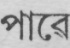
পাৱে
